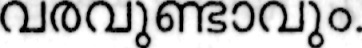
വരവുണ്ടാവും.
